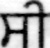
ਸੀ
